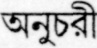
অনুচরী
